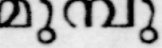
മുമ്പു
